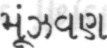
મૂંઝવણ
